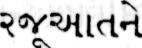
રજૂઆતને
